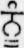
ਨੂੰ
